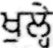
ਖੁਲ੍ਹੇ
